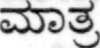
ಮಾತ್ರ
